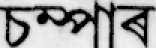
চম্পাৰ
